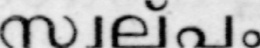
സ്വല്പം
